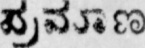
ಪ್ರಮಾಣ
